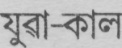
যুৱা-কাল
